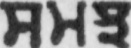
ਸਮਝ
